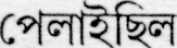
পেলাইছিল
